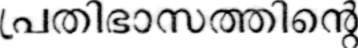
പ്രതിഭാസത്തിന്റെ
